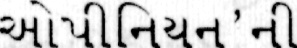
ઓપીનિયન'ની
